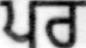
ਪਰ
